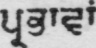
ਪ੍ਰਭਾਵਾਂ
